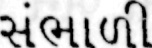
સંભાળી
